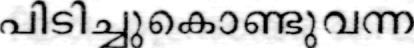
പിടിച്ചുകൊണ്ടുവന്ന
